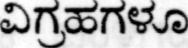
ವಿಗ್ರಹಗಳೂ
